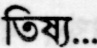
তিষ্য...
